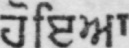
ਹੋਇਆ
